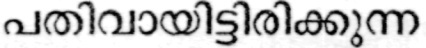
പതിവായിട്ടിരിക്കുന്ന
